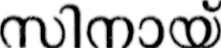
സിനായ്
